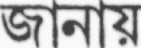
জানায়
